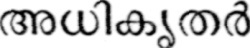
അധികൃതര്‍
